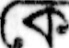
কে
